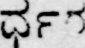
ರ್ಧರ
